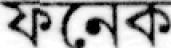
ফনেক
